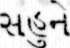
સહુને
